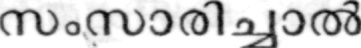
സംസാരിച്ചാല്‍
